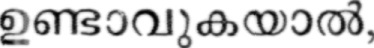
ഉണ്ടാവുകയാല്‍,
